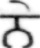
ਨੇ
